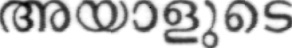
അയാളുടെ
